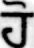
ਹੋ
